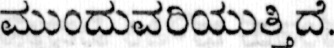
ಮುಂದುವರಿಯುತ್ತಿದೆ.
